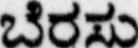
ಬೆರಸು
